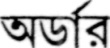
অর্ডার
